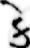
કે
